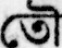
তৌ
